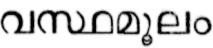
വസ്ഥമൂലം
